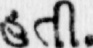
હતી.
